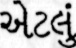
એટલું
